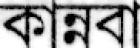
কান্নবা
